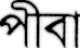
পীবা
